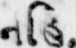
નહિ.
